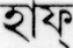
হাফ্
